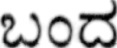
ಬಂದ
